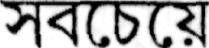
সবচেয়ে
